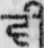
ਵੀ
